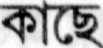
কাছে
